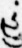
હું
